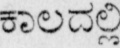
ಕಾಲದಲ್ಲಿ
